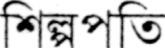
শিল্পপতি
